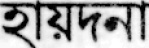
হায়দনা
